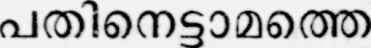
പതിനെട്ടാമത്തെ
